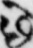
છે
